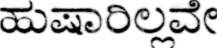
ಹುಷಾರಿಲ್ಲವೇ
